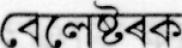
বেলেষ্টৰক
